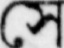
সে
